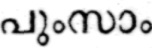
പുംസാം
